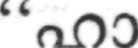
"ഹാ
